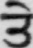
ਤੇ
